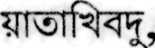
য়াতাখিবদু,
